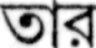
তার
